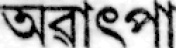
অৱাৎপা
